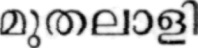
മുതലാളി
